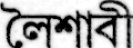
লৈশাবী
